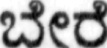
ಬೇರೆ
